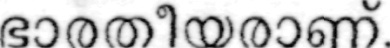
ഭാരതീയരാണ്.
